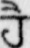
ਹੈ
